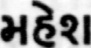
મહેશ
